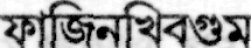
ফাজিনখিবগুম
